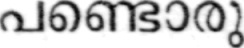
പണ്ടൊരു
